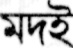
মদই
